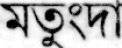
মতুংদা
